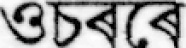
ওচৰৰে
